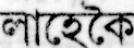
লাহেকৈ
